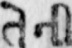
તેની
